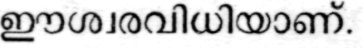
ഈശ്വരവിധിയാണ്.
